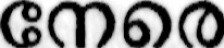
നേരെ
